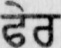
ਫੇਰ
